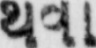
થવા
